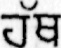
ਹੱਥ
